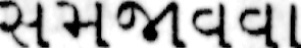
સમજાવવા
